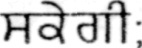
ਸਕੇਗੀ;
